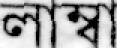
লাম্বা
